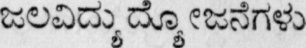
ಜಲವಿದ್ಯುದ್ಯೋಜನೆಗಳು
